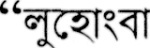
“লুহোংবা
